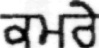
ਕਮਰੇ
